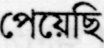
পেয়েছি
